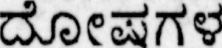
ದೋಷಗಳ
